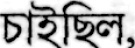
চাইছিল,
